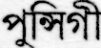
পুন্সিগী
